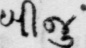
બીજું
